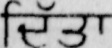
ਦਿੱਤਾ
